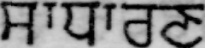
ਸਾਧਾਰਣ
